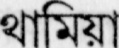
থামিয়া
